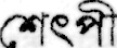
শেৎপী
